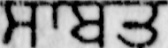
ਸਾਬਤ
